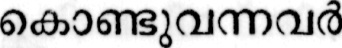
കൊണ്ടുവന്നവര്‍
